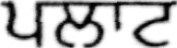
ਪਲਾਟ
